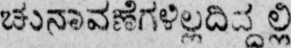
ಚುನಾವಣೆಗಳಿಲ್ಲದಿದ್ದಲ್ಲಿ
